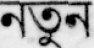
নতুন
